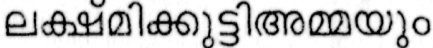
ലക്ഷ്മിക്കുട്ടിഅമ്മയും
